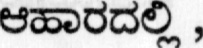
ಆಹಾರದಲ್ಲಿ,
